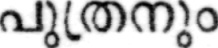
പുത്രനും
